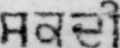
ਸਕਦੀ
